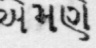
એમણે
